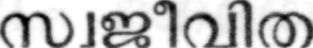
സ്വജീവിത
